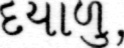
દયાળુ,
